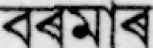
বৰমাৰ
